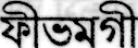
ফীভমগী
